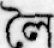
লৈ
